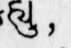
કહ્યું,
